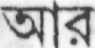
আর
